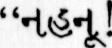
"નહનૂ!
